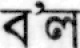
ব'ল
